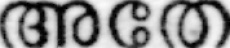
അതേ
